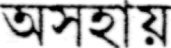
অসহায়
